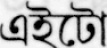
এইটো
